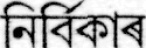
নির্বিকাৰ
